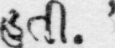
હતી.'
